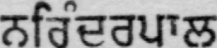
ਨਰਿੰਦਰਪਾਲ
